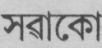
সৱাকো
